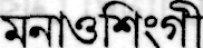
মনাওশিংগী
